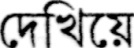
দেখিয়ে
